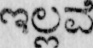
ಇಲ್ಲವೆ
